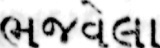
ભજવેલા
